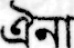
ঐনা
